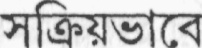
সক্রিয়ভাবে
